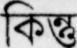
কিন্তু
